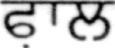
ਫ਼ਾਲ
